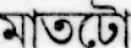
মাতটো
